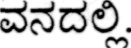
ವನದಲ್ಲಿ.
